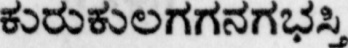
ಕುರುಕುಲಗಗನಗಭಸ್ತಿ
